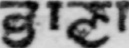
ਭਾਣਾ
